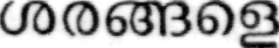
ശരങ്ങളെ
